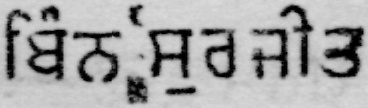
ਬਿੰਨਸੁਰਜੀਤ
